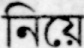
নিয়ে
